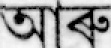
আৰু
